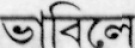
ভাবিলে
